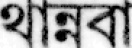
থান্নবা
